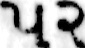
પર
